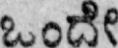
ಒಂದೇ
